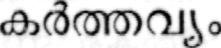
കര്‍ത്തവ്യം
